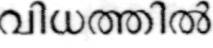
വിധത്തില്‍
